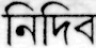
নিদিব
